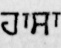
ਹਾਸਾ
